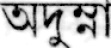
অদুম্না
